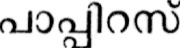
പാപ്പിറസ്
